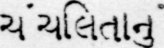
ચંચલિતાનું
